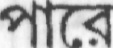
পারে
